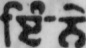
ਇੰਨੇ
